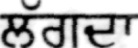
ਲੱਗਦਾ
